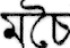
মচৈ
